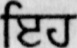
ਇਹ
